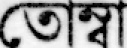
তোম্বা
